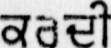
ਕਰਦੀ
